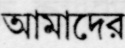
আমাদের
